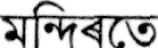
মন্দিৰতে
